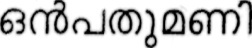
ഒന്‍പതുമണി
